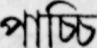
পাচ্চি
